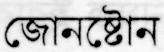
জোনষ্টোন
